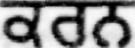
ਕਰਨ
